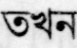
তখন
